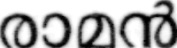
രാമന്‍
